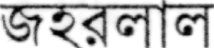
জহরলাল
